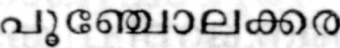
പൂഞ്ചോലക്കര
